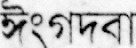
ঈংগদবা
